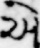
એ
